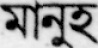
মানুহ
